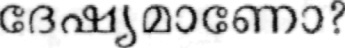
ദേഷ്യമാണോ?
